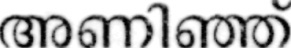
അണിഞ്ഞ്
